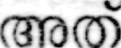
അത്
